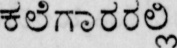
ಕಲೆಗಾರರಲ್ಲಿ
